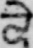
ਕੇ
